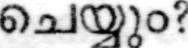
ചെയ്യും?
